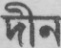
দীন
